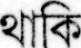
থাকি
